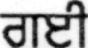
ਗਈ
